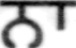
ਨਾ
